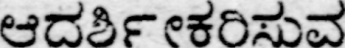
ಆದರ್ಶೀಕರಿಸುವ
